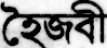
হৈজবী
